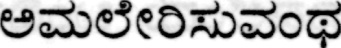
ಅಮಲೇರಿಸುವಂಥ
